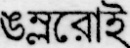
ঙম্লরোই
